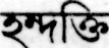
হন্দক্তি
